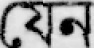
যেন
